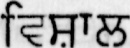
ਵਿਸ਼ਾਲ
